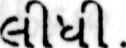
લીધી.
